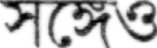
সঙ্গেও
